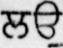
ਲਉ
